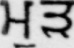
ਮੁੜ
